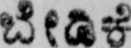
ಬೇಡಿಕೆ
